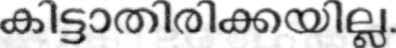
കിട്ടാതിരിക്കയില്ല.
